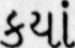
કયાં
